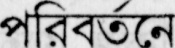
পরিবর্তনে
